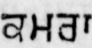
ਕਮਰਾ
